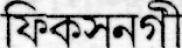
ফিকসনগী
